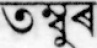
তম্বুৰ
